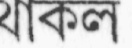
থাকল
